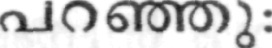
പറഞ്ഞു:
